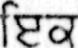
ਇਕ
